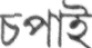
চপাই
